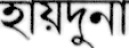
হায়দুনা
